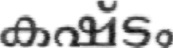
കഷ്ടം
